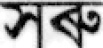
সৰু
